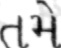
તમે
